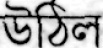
উঠিল
